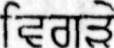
ਵਿਗੜੇ
